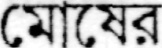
মোষের
